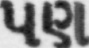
પણ
